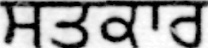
ਸਤਕਾਰ
